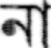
না
